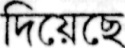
দিয়েছে
